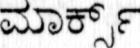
ಮಾರ್ಕ್ಸ್
